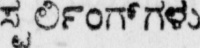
ಸ್ಟರ್ಲಿಂಗ್‌ಗಳು
